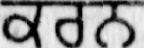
ਕਰਨ
